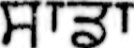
ਸਾਡਾ
